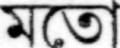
মতো
